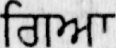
ਗਿਆ
